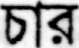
চার
